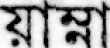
য়াম্না
